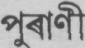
পুৰাণী
